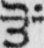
ਤੋਂ
